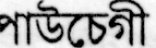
পাউচেগী
